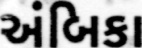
અંબિકા
